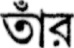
তাঁর
